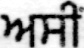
ਅਸੀਂ
